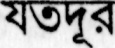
যতদূর
